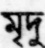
মৃদু
